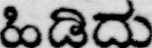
ಹಿಡಿದು
